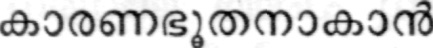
കാരണഭൂതനാകാന്‍
